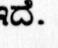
ಇದೆ.
